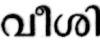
വീശി
